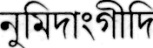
নুমিদাংগীদি
